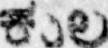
ಕುಲ
